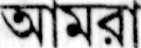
আমরা
